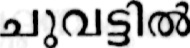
ചുവട്ടില്‍
